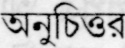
অনুচিত্তর
